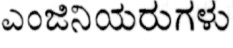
ಎಂಜಿನಿಯರುಗಳು
